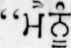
''ਮੈਨੂੰ
